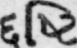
દ્દષ્ટિ
